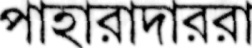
পাহারাদাররা
